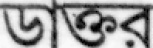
ডাক্তর
